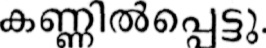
കണ്ണില്‍പ്പെട്ടു.
